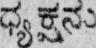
ಧ್ಯಕ್ಷನು
